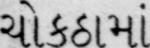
ચોકઠામાં
